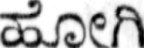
ಹೋಗಿ
